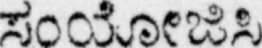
ಸಂಯೋಜಿಸಿ
